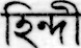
হিন্দী
